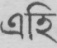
এহি
